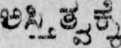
ಅಸ್ತಿತ್ವಕ್ಕೆ
